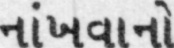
નાંખવાનો
